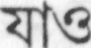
যাও
